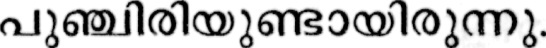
പുഞ്ചിരിയുണ്ടായിരുന്നു.
